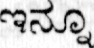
ಇನ್ನೂ
